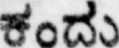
ಕಂದು
